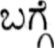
ಬಗ್ಗೆ
